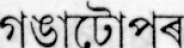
গঙাটোপৰ
